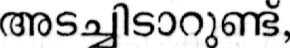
അടച്ചിടാറുണ്ട്,
